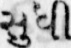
સુધી
